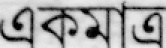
একমাত্র
